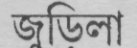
জুড়িলা
